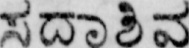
ಸದಾಶಿವ
